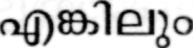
എങ്കിലും
